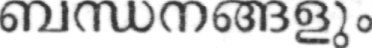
ബന്ധനങ്ങളും
